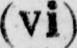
(vi)
